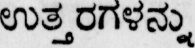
ಉತ್ತರಗಳನ್ನು
